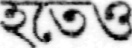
হতেও
